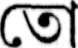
তো
